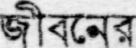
জীবনের
